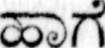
ಹಾಗೆ
